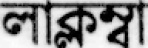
লাক্লম্বা
